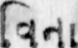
વિના
